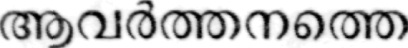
ആവര്‍ത്തനത്തെ
